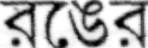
রঙের
